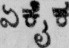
ಏಕೈಕ
